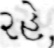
રહે,
